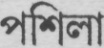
পশিলা
